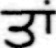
ਤਾਂ
